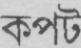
কপট
